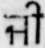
ਜੀ
